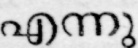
എന്നു
